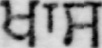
ਖਾਸ
